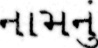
નામનું
